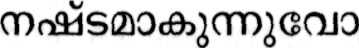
നഷ്ടമാകുന്നുവോ
